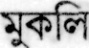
মুকলি
